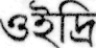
ওইদ্রি
